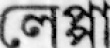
লেপ্পা
